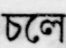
চলে
